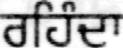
ਰਹਿੰਦਾ
